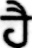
ਹੈ
